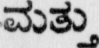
ಮತ್ತು
